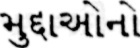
મુદ્દાઓનો
